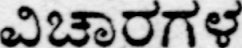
ವಿಚಾರಗಳ
